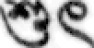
শুৎ
